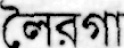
লৈরগা
